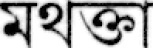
মথক্তা
